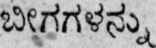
ಬೀಗಗಳನ್ನು
